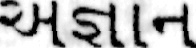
અજ્ઞાન
